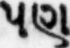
પણ
